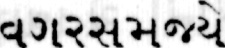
વગરસમજ્યે
